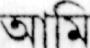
আমি
